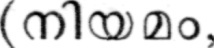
(നിയമം,
